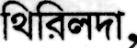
থিরিলদা,
